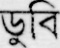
ডুবি
